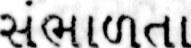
સંભાળતા
